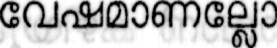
വേഷമാണല്ലോ
